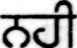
ਨਹੀਂ
